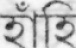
হাঁহি
